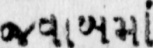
જવાબમાં
